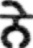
ਨੇ
